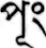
পূং
